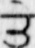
ਤੇ
